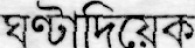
ঘণ্টাদিয়েক
